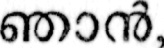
ഞാന്‍,
